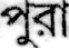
পুরা
